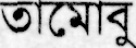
তামোবু
